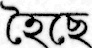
হৈছে
